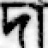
দা
